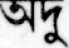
অদু
